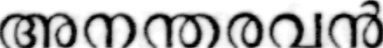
അനന്തരവന്‍
